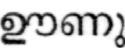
ഊണു
